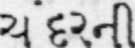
ચંદરની
